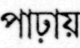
পাঢ়ায়
